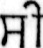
ਸੀ
